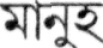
মানুহ
